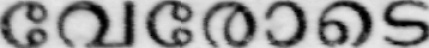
വേരോടെ
